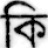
কি
